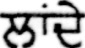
ਲਾਂਦੇ
